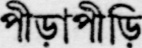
পীড়াপীড়ি
